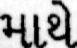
માથે
